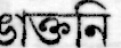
ঙাক্তনি
